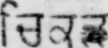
ਚਿਕੜ
